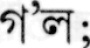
গ'ল;
